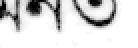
মনত
